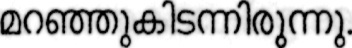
മറഞ്ഞുകിടന്നിരുന്നു.
